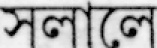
সলালে
